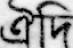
ঐদি
